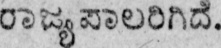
ರಾಜ್ಯಪಾಲರಿಗಿದೆ.
